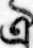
ঐ
